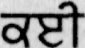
ਕਈ
